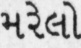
મરેલો
